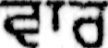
ਵਾਰ
